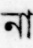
না
